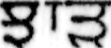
ਝਾੜ
